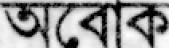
অবোক
